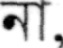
না,
